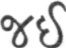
જઈ
